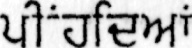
ਪੀਂਹਦਿਆਂ
